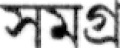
সমগ্র
